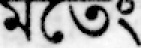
মতেং
